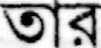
তার
